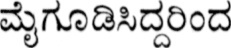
ಮೈಗೂಡಿಸಿದ್ದರಿಂದ
